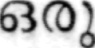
ഒരു
